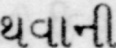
થવાની
